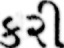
કરી
